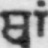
ਥਾਂ
